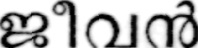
ജീവന്‍
